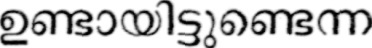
ഉണ്ടായിട്ടുണ്ടെന്ന
